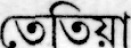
তেতিয়া
